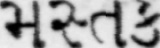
મસ્તક
